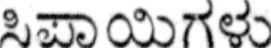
ಸಿಪಾಯಿಗಳು
